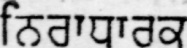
ਨਿਰਾਧਾਰਕ
